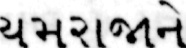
યમરાજાને
